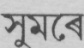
সুমৰে
